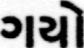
ગયો
